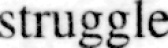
struggle
